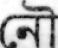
নৌ
